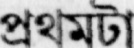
প্রথমটা
